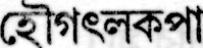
হৌগৎলকপা
